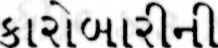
કારોબારીની
